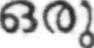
ഒരു
